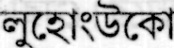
লুহোংউকো
